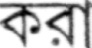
করা
